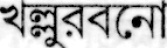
খল্লুরবনো
